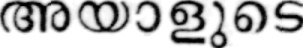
അയാളുടെ
